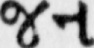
જન
